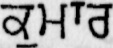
ਕੁਮਾਰ
